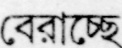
বেরাচ্ছে
